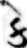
કે
